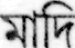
মাদি
